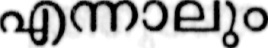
എന്നാലും
